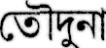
তৌদুনা
